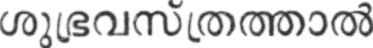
ശുഭ്രവസ്ത്രത്താല്‍
